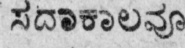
ಸದಾಕಾಲವೂ
